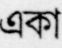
একা
